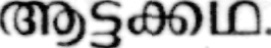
ആട്ടക്കഥ.
